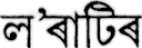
ল'ৰাটিৰ
